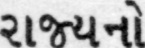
રાજ્યનો
